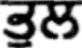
ਭੁਲ
